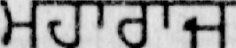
ਮਹਾਰਾਜ
